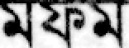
মফম
